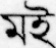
মই
